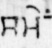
ਸਮੇਂ
